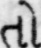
તો
